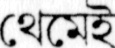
থেমেই
